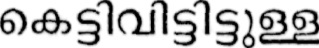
കെട്ടിവിട്ടിട്ടുള്ള
